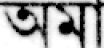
অমা
